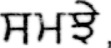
ਸਮਝੇ,
